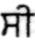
ਸੀ
